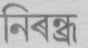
নিৰন্ধ্ৰ
